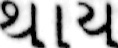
થાય
